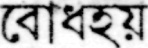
বোধহয়
